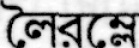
লৈরম্লে
